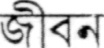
জীবন
